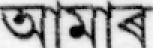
আমাৰ
